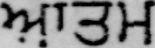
ਆਤਮ
